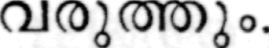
വരുത്തും.
